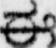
ಈ
